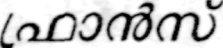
ഫ്രാന്‍സ്
